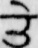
ਤੇ
